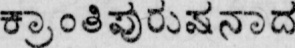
ಕ್ರಾಂತಿಪುರುಷನಾದ
